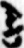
કે
